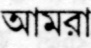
আমরা
